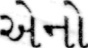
એનો
